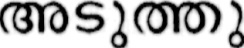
അടുത്തു
